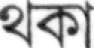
থকা
